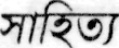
সাহিত্য
